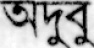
অদুবু
